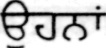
ਉਹਨਾਂ
